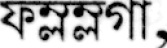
ফম্লম্লগা,
